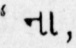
'ના,
